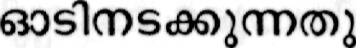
ഓടിനടക്കുന്നതു
